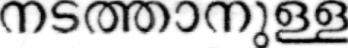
നടത്താനുള്ള
